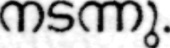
നടന്നു.
